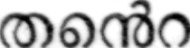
തന്റെ
